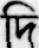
দি
